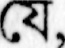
যে,
